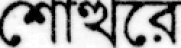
শোত্থরে
